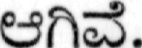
ಆಗಿವೆ.
